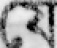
যে
